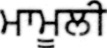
ਮਾਮੂਲੀ
